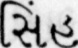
સિંહ
